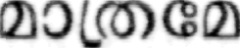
മാത്രമേ
